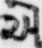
એ
